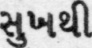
સુખથી
